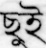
ছুই
